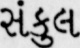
સંકુલ
